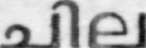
ചില
